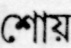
শোয়
